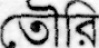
তৌরি
